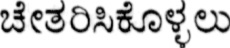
ಚೇತರಿಸಿಕೊಳ್ಳಲು
